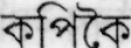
কপিকৈ
